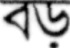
বড়
